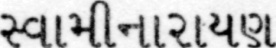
સ્વામીનારાયણ
